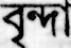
বৃন্দা
